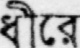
ধীরে
